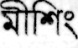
মীশিং
